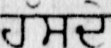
ਹੱਸਦੇ
